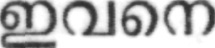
ഇവനെ
